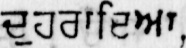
ਦੁਹਰਾਇਆ,
